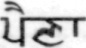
ਪੈਣਾ
